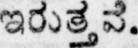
ಇರುತ್ತವೆ.
